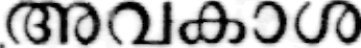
അവകാശ
